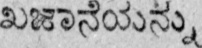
ಖಜಾನೆಯನ್ನು
